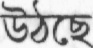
উঠছে
